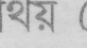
থিয়
